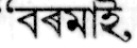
"বৰমাই,
